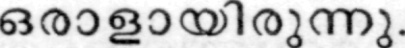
ഒരാളായിരുന്നു.
